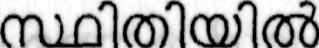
സ്ഥിതിയില്‍
